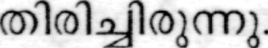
തിരിച്ചിരുന്നു.
